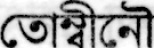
তোম্বীনৌ
